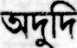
অদুদি
